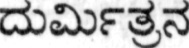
ದುರ್ಮಿತ್ರನ
